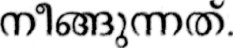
നീങ്ങുന്നത്.
